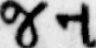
જન
